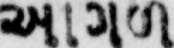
આગળ
